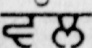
ਵੱਲ
